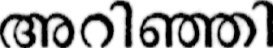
അറിഞ്ഞി
